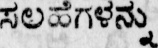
ಸಲಹೆಗಳನ್ನು
